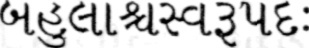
બહુલાશ્વસ્વરૂપદઃ
